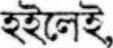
হইলেই,
